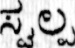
ಸ್ವಲ್ಪ
